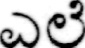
ಎಲೆ
